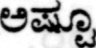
ಅಷ್ಟೂ
